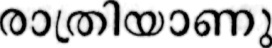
രാത്രിയാണു
